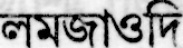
লমজাওদি
